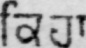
ਕਿਹਾ
